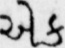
એક
